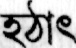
হঠাৎ
